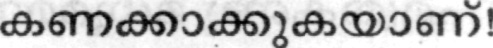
കണക്കാക്കുകയാണ്!
